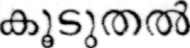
കൂടുതല്‍
